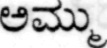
ಅಮ್ಮು
